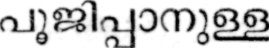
പൂജിപ്പാനുള്ള
